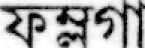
ফম্লগা
